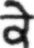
ਕੇ
